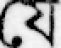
যে
